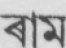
ৰাম
